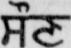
ਸੌਣ
